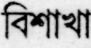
বিশাখা
